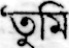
'তুমি
